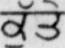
ਕੁੱਤੇ
